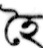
হৈ
